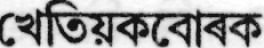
খেতিয়কবোৰক
